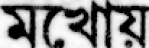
মখোয়
